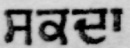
ਸਕਦਾ
